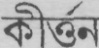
কীৰ্ত্তন
